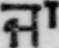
ਜਾ
